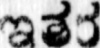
ಇತರ
